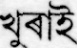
খুৰাই
